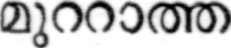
മുററാത്ത
